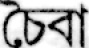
চৈবা
